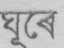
ঘূৰে
